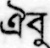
ঐবু
